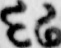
દ્દઢ
